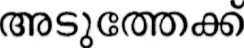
അടുത്തേക്ക്
